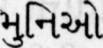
મુનિઓ
